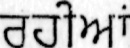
ਰਹੀਆਂ
